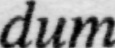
dum
